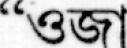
“ওজা
